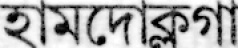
হামদোক্লগা
